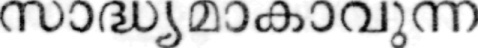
സാദ്ധ്യമാകാവുന്ന
